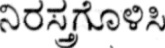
ನಿರಸ್ತ್ರಗೊಳಿಸಿ
